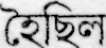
হৈছিল
